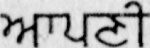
ਆਪਣੀ
